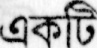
একটি
